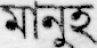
মানুহ
